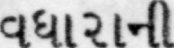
વધારાની
